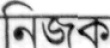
নিজক
